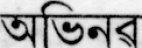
অভিনৱ
